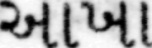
આખા
